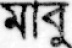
মাবু
